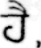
ਹੈ,
